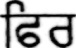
ਫਿਰ
